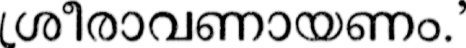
ശ്രീരാവണായണം.’
